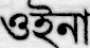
ওইনা
